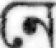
নে
